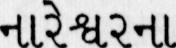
નારેશ્વરના
